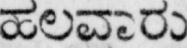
ಹಲವಾರು
